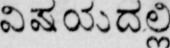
ವಿಷಯದಲ್ಲಿ
